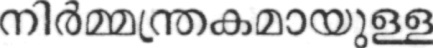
നിര്‍മ്മന്ത്രകമായുള്ള
